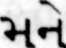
મને
